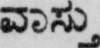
ವಾಸ್ತು
